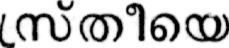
സ്രതീയെ
